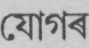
যোগৰ
